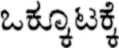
ಒಕ್ಕೂಟಕ್ಕೆ
